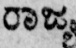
ರಾಜ್ಯ
